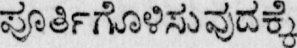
ಪೂರ್ತಿಗೊಳಿಸುವುದಕ್ಕೆ
